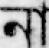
না
